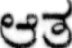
ಆತ
